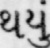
થયું
